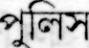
পুলিস
